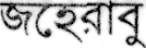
জহেরাবু
